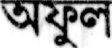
অফুল
